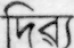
দিৱ্য
